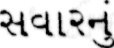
સવારનું
